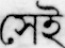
সেই
